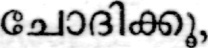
ചോദിക്കൂ,
